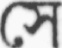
সে
